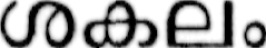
ശകലം
